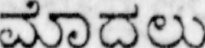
ಮೊದಲು
